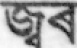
জ্বৰ
